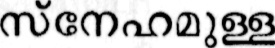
സ്നേഹമുള്ള
